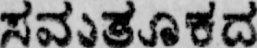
ಸಮತೂಕದ
